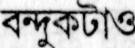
বন্দুকটাও
